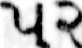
પર
